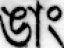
ঙাং
